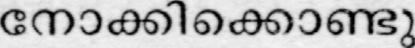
നോക്കിക്കൊണ്ടു
